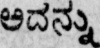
ಅದನ್ನು
